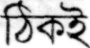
ঠিকই
